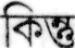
কিন্তু
